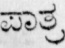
ಪಾತ್ರ
